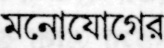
মনোযোগের
